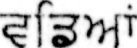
ਵਡਿਆਂ
